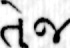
તેજ
